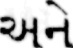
અને
